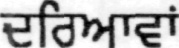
ਦਰਿਆਵਾਂ
